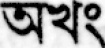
অখং
